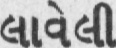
લાવેલી
